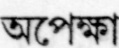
অপেক্ষা
